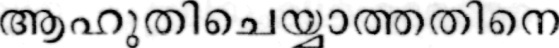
ആഹുതിചെയ്യാത്തതിനെ
